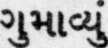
ગુમાવ્યું
